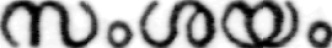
സംശയം
